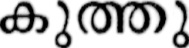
കുത്തു
